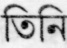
তিনি
